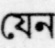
যেন
